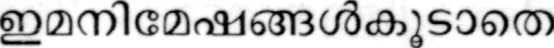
ഇമനിമേഷങ്ങള്‍കൂടാതെ
